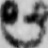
ಆ
